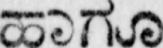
ಹಾಗೂ
